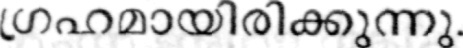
ഗ്രഹമായിരിക്കുന്നു.
